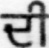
ਦੀ
